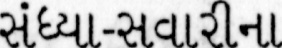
સંધ્યા-સવારીના
